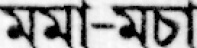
মমা-মচা
